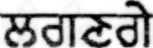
ਲਗਣਗੇ
